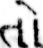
તો
